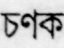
চণক
